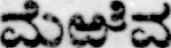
ಮೆಱೆವ
